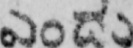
ಎಂದು
